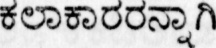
ಕಲಾಕಾರರನ್ನಾಗಿ
